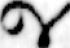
જ
